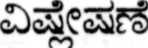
ವಿಷ್ಲೇಷಣೆ
